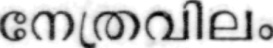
നേത്രവിലം
